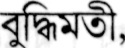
বুদ্ধিমতী,
